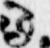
છે.
